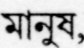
মানুষ,
